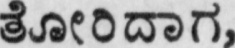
ತೋರಿದಾಗ,
